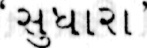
'સુધારા'
